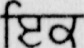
ਇਕ
